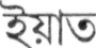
ইয়াত
